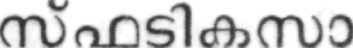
സ്ഫടികസാ
